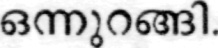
ഒന്നുറങ്ങി.
